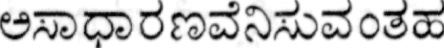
ಅಸಾಧಾರಣವೆನಿಸುವಂತಹ
